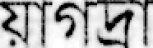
য়াগদ্রা
